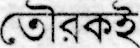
তৌরকই
